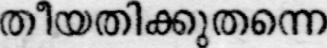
തീയതിക്കുതന്നെ
